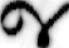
જ
